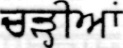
ਚੜ੍ਹੀਆਂ
